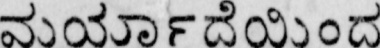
ಮರ್ಯಾದೆಯಿಂದ
